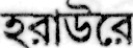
হরাউরে
